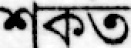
শকত
